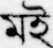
মই
